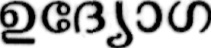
ഉദ്യോഗ
